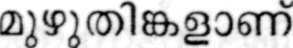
മുഴുതിങ്കളാണ്
